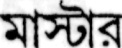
মাস্টার
